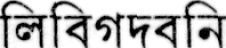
লিবিগদবনি
